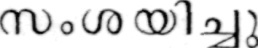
സംശയിച്ചു
